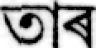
তাৰ
